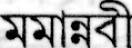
মমান্নবী
